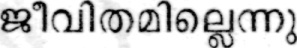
ജീവിതമില്ലെന്നു
